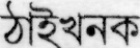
ঠাইখনক
